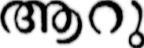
ആറു
